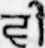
ਵੀ
